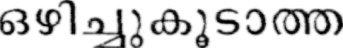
ഒഴിച്ചുകൂടാത്ത
